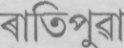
ৰাতিপুৱা
